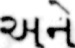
અને
